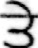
ਤੇ
